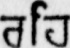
ਰਹਿ
